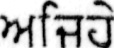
ਅਜਿਹੇ
